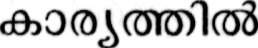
കാര്യത്തില്‍
